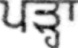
ਪੜ੍ਹਾ
